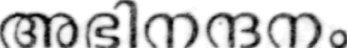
അഭിനന്ദനം
